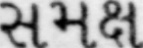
સમક્ષ
